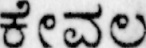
ಕೇವಲ
